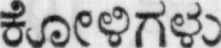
ಕೋಳಿಗಳು
